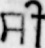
ਸੀ
